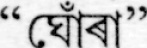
"ঘোঁৰা"
